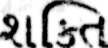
શક્તિ
